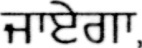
ਜਾਏਗਾ,
